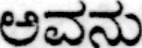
ಅವನು
